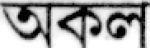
অকল
